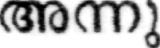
അന്നു
